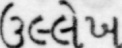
ઉલ્લેખ
